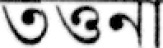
তত্তনা
